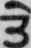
ਤੇ
